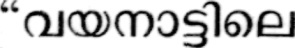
“വയനാട്ടിലെ
